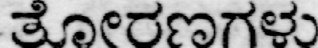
ತೋರಣಗಳು
